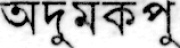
অদুমকপু
